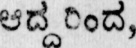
ಆದ್ದರಿಂದ,
